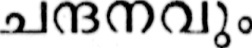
ചന്ദനവും
